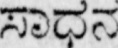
ಸಾಧನ
